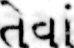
તેવાં
